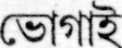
ভোগাই
